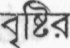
বৃষ্টির
